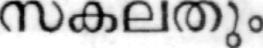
സകലതും
